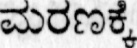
ಮರಣಕ್ಕೆ
